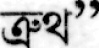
ত্রুথ”
